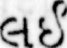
લઈ
